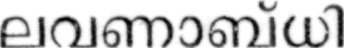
ലവണാബ്ധി
